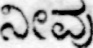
ನೀವು
